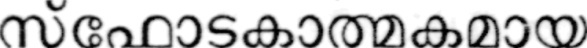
സ്ഫോടകാത്മകമായ
